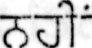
ਨਹੀਂ
